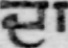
ਦਾ
